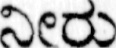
ನೀರು
